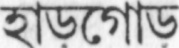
হাড়গোড়
